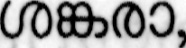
ശങ്കരാ,
